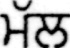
ਮੱਲ
